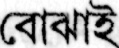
বোঝাই
